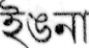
ইঙনা
